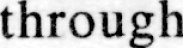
through
